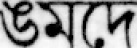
ঙমদে
